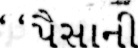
"પૈસાની
